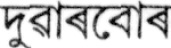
দুৱাৰবোৰ
